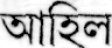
আহিল
